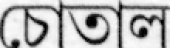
চোতাল
